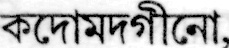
কদোমদগীনো,
